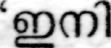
‘ഇനി
